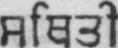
ਸਥਿਤੀ
